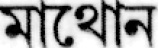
মাথোন
